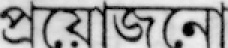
প্রয়োজনো
